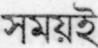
সময়ই
